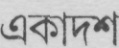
একাদশ
